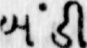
બંડી
